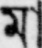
মা
